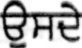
ਉਸਦੇ
